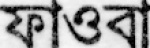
ফাওবা
